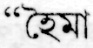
“হৈমা
